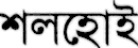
শলহৌই
